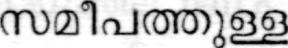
സമീപത്തുള്ള
